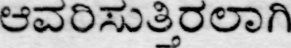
ಆವರಿಸುತ್ತಿರಲಾಗಿ
